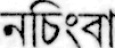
নচিংবা
